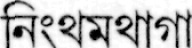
নিংথমথাগা
